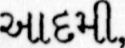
આદમી,
